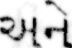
અને
